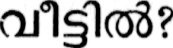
വീട്ടില്‍?
